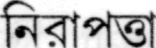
নিরাপত্তা
